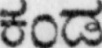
ಕಂಡ
